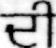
ਦੀ
